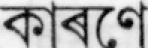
কাৰণে
